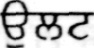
ਉਲਟ
